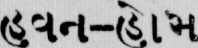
હવન-હોમ
